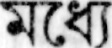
মধ্যে
